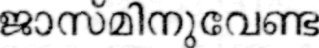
ജാസ്മിനുവേണ്ട
